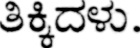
ತಿಕ್ಕಿದಳು.
